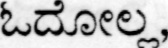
ಓದೋಲ್ಲ,
